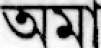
অমা
